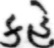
કહે
